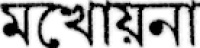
মখোয়না
